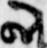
જો
